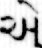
એ
